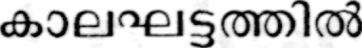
കാലഘട്ടത്തില്‍
